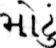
મોટું
